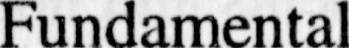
Fundamental
